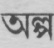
অল্প
